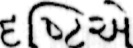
દષ્ટિએ
